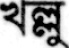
খল্লু
